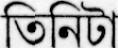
তিনিটা
